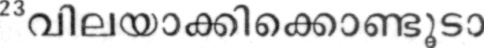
23വിലയാക്കിക്കൊണ്ടൂടാ
